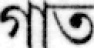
গাত
